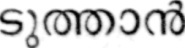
ടുത്താന്‍
